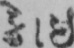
કોઈ
